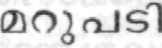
മറുപടി
